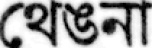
থেঙনা
